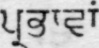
ਪ੍ਰਭਾਵਾਂ
